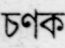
চণক
